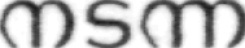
നടന്ന
